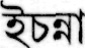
ইচন্না
